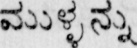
ಮುಳ್ಳನ್ನು
